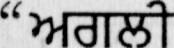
''ਅਗਲੀ
